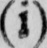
(i)
